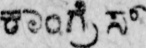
ಕಾಂಗ್ರೆಸ್
